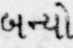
બન્યો
